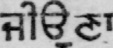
ਜੀਉਣਾ
